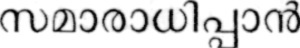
സമാരാധിപ്പാന്‍
